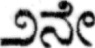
೨ನೇ
